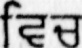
ਵਿਚ
